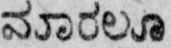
ಮಾರಲೂ
